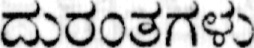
ದುರಂತಗಳು
